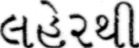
લહેરથી
